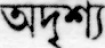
অদৃশ্য
